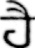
ਹੈ
